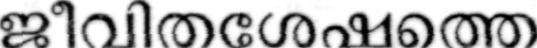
ജീവിതശേഷത്തെ
